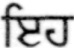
ਇਹ
